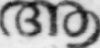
ആ
